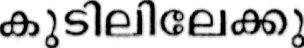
കുടിലിലേക്കു
